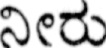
ನೀರು
